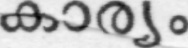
കാര്യം
